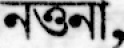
নত্তনা,
